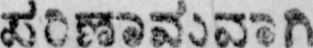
ಪರಿಣಾಮವಾಗಿ
